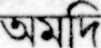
অমদি
